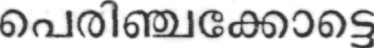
പെരിഞ്ചക്കോട്ടെ
